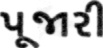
પૂજારી
